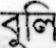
বুলি
